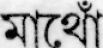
মাথোঁ
